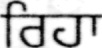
ਰਿਹਾ
